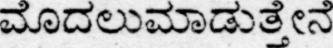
ಮೊದಲುಮಾಡುತ್ತೇನೆ
